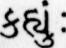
કહ્યું:
